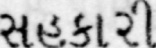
સહકારી
